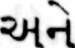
અને
